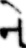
ને
